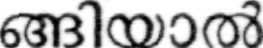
ങ്ങിയാല്‍
